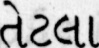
તેટલા
